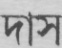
দাস
